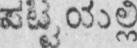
ಪಟ್ಟಿಯಲ್ಲಿ
